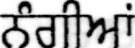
ਨੰਗੀਆਂ
